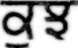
ਕੁਝ
